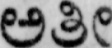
ಅತೀ
